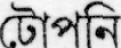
টোপনি
